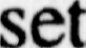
Set
